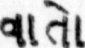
વાતો
